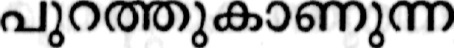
പുറത്തുകാണുന്ന
